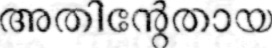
അതിന്റേതായ
